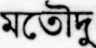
মতৌদু
